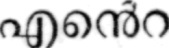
എന്റെ
